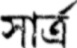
সার্ত্র
